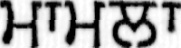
ਮਾਮਲਾ
